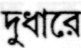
দুধারে
